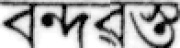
বন্দৱস্ত
